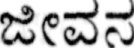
ಜೀವನ
